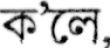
ক'লে,
